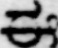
ಈ
